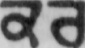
ਕਰ
